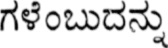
ಗಳೆಂಬುದನ್ನು
